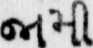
જામી
